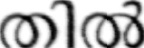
തില്‍
